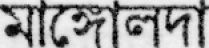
মাঙ্গোলদা
